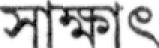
সাক্ষাৎ
